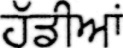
ਹੱਡੀਆਂ
